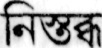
নিস্তব্ধ
